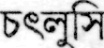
চৎলুসি
